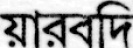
য়ারবদি
